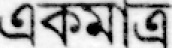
একমাত্র
